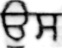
ਉਸ
